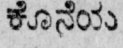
ಕೊನೆಯ
